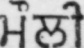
ਮੌਲੀ
